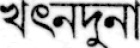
খৎনদুনা
